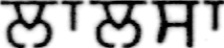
ਲਾਲਸਾ
